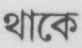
থাকে
